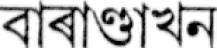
বাৰাণ্ডাখন
